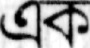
এক
